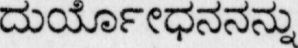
ದುರ್ಯೋಧನನನ್ನು
